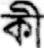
কী
